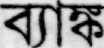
ব্যাঙ্ক
